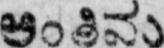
ಅಂತಿಮ
